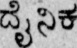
ದೈನಿಕ
